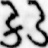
કેડે
